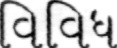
વિવિધ
